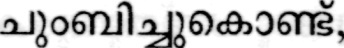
ചുംബിച്ചുകൊണ്ട്,
